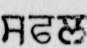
ਸਫਲ
